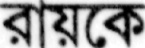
রায়কে
